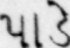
પાડે
